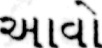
આવો
